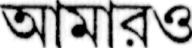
আমারও
